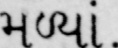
મળ્યાં.
